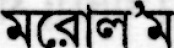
মরোল’ম
